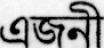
এজনী
